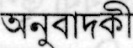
অনুবাদগী
